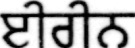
ਈਰੀਨ
